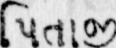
પિતાજી
